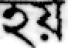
হয়
